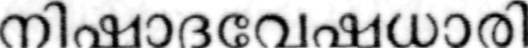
നിഷാദവേഷധാരി
